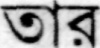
তার
